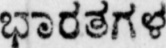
ಭಾರತಗಳ
